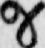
જ
